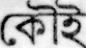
কৌই
